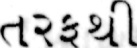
તરફથી
